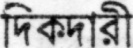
দিকদারী
